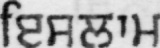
ਇਸਲਾਮ
